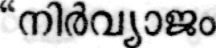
"നിര്‍വ്യാജം
